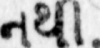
નથી.
